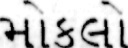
મોકલો
